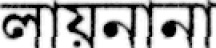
লায়নানা
